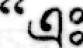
“এঃ
